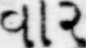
વાર
